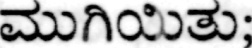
ಮುಗಿಯಿತು;
